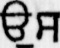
ਉਸ
